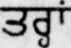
ਤਰ੍ਹਾਂ
